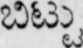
ಬಿಟ್ಟು
